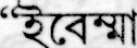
“ইবেম্মা
